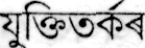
যুক্তিতর্কৰ
